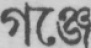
গঞ্জে
